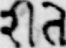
રીતે
